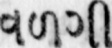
વળગી
